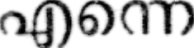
എന്നെ
